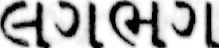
લગભગ
